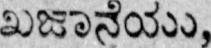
ಖಜಾನೆಯು,
